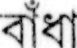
বাঁধা
